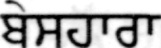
ਬੇਸਹਾਰਾ
